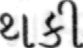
થકી
